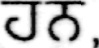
ਹਨ,
